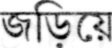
জড়িয়ে
